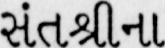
સંતશ્રીના
